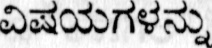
ವಿಷಯಗಳನ್ನು
